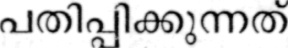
പതിപ്പിക്കുന്നത്
